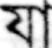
যা
